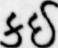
કઈ
